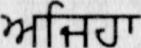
ਅਜਿਹਾ
